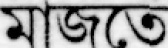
মাজতে
